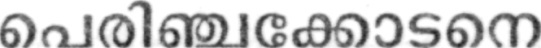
പെരിഞ്ചക്കോടനെ
